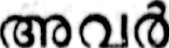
അവര്‍
